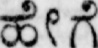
ಹೇಗೆ
